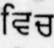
ਵਿਚ
